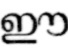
ഈ
